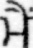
ਮੈਂ
